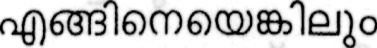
എങ്ങിനെയെങ്കിലും
